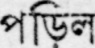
পড়িল
